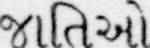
જાતિઓ
